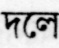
দলে
